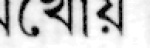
মখোয়
